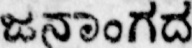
ಜನಾಂಗದ
